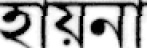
হায়না
